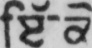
ਇੱਕੋ
